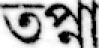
তপ্না
